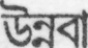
উন্নবা
